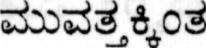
ಮುವತ್ತಕ್ಕಿಂತ
